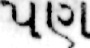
પણ
